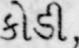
કોડી,
